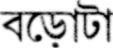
বড়োটা
